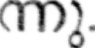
ന്നു.
